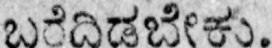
ಬರೆದಿಡಬೇಕು.
